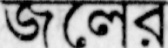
জলের
